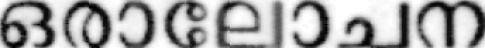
ഒരാലോചന
